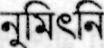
নুমিৎনি
